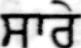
ਸਾਰੇ
